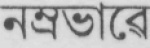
নম্ৰভাৱে
